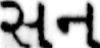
સન
